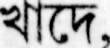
খাদে,
